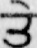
ਤੇ
